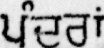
ਪੰਦਰਾਂ
